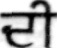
ਦੀ
